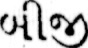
બીજી
